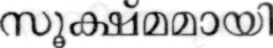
സൂക്ഷ്മമായി
